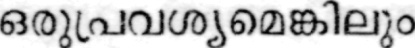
ഒരുപ്രാവശ്യമെങ്കിലും
